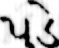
પડે
